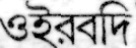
ওইরবদি
